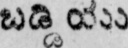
ಬಡ್ಡಿಯು
